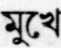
মুখে
